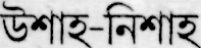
উশাহ-নিশাহ
